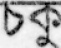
চকু
